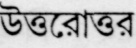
উত্তরোত্তর
